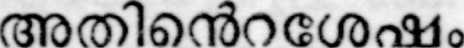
അതിന്റെശേഷം
